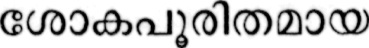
ശോകപൂരിതമായ
